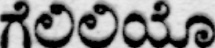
ಗೆಲಿಲಿಯೊ
